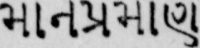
માનપ્રમાણ
